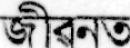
জীৱনত
